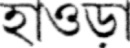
হাওড়া
